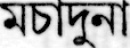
মচানুপা
